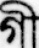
গী
